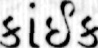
કાંઈક
